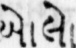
બોલો
